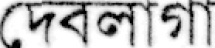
দেবলগা
